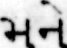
મને
